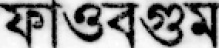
ফাওবগুম
